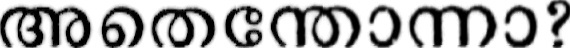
അതെന്തോന്നാ?
